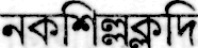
নকশিল্লক্লদি
